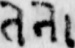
તેનો
